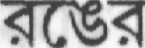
রঙের
